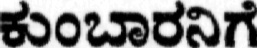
ಕುಂಬಾರನಿಗೆ
